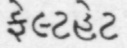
ફેલ્ટહેટ
